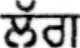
ਲੱਗ
